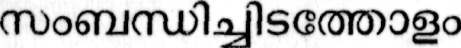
സംബന്ധിച്ചിടത്തോളം
